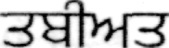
ਤਬੀਅਤ
